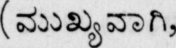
(ಮುಖ್ಯವಾಗಿ,
